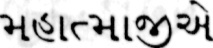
મહાત્માજીએ
